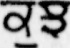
ਕੁਝ
